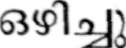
ഒഴിച്ചു
